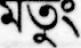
মতুং
